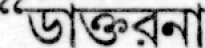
“ডাক্তরনা
